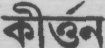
কীৰ্ত্তন
